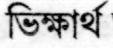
ভিক্ষার্থ
